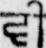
ਵੀ
